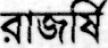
রাজর্ষি
